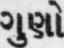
ગુણો
